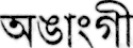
অঙাংগী
